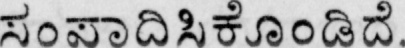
ಸಂಪಾದಿಸಿಕೊಂಡಿದೆ.
